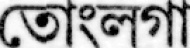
তোংলগা
